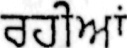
ਰਹੀਆਂ
